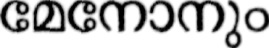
മേനോനും
